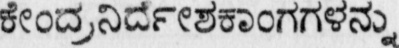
ಕೇಂದ್ರನಿರ್ದೇಶಕಾಂಗಗಳನ್ನು
